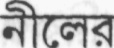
নীলের
